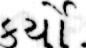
કર્યો.
